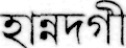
হান্নদগী
